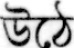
উঠে
